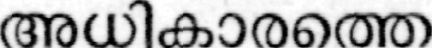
അധികാരത്തെ
